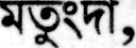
মতুংদা,
